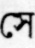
সে
